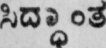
ಸಿದ್ದಾಂತ
